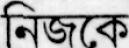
নিজকে
